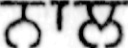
ਨਾਲ
